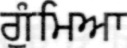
ਗੁੰਮਿਆ
